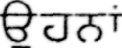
ਉਹਨਾਂ
